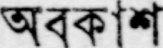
অবকাশ
